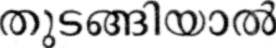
തുടങ്ങിയാല്‍
